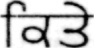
ਕਿਤੇ
